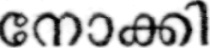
നോക്കി
